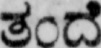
ತಂದೆ
